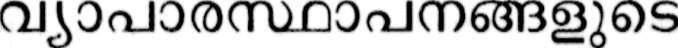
വ്യാപാരസ്ഥാപനങ്ങളുടെ
